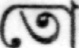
তো
